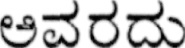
ಅವರದು
